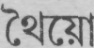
থৈয়ো
